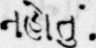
નહોતું.
